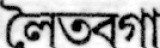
লৈতবগা
